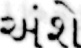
અંશે
